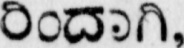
ರಿಂದಾಗಿ,
